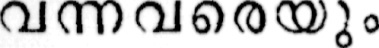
വന്നവരെയും
